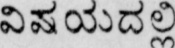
ವಿಷಯದಲ್ಲಿ
